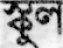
স্কুল
